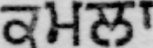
ਕਮਲਾ
